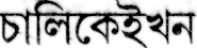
চালিকেইখন
